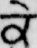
ਕੇ
